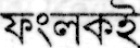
ফংলকই
